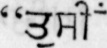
''ਤੁਸੀਂ
